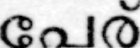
പേര്
